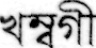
খম্বগী
